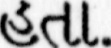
હતા.
